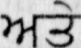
ਅਤੇ
